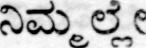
ನಿಮ್ಮಲ್ಲೇ
